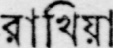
রাখিয়া
